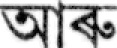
আৰু
